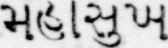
મહાસુખ
